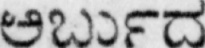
ಅರ್ಬುದ
